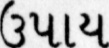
ઉપાય
